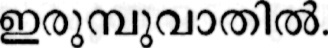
ഇരുമ്പുവാതില്‍.
